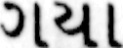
ગયા
